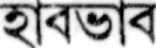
হাবভাব
